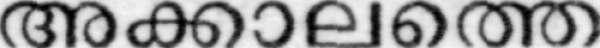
അക്കാലത്തെ
